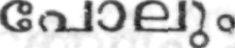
പോലും
